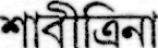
শাবীত্রিনা
